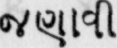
જણાવી
